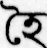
হৈ
